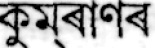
কুম্‌ৰাণৰ
